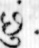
છું.
